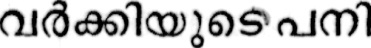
വര്‍ക്കിയുടെപനി
